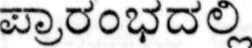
ಪ್ರಾರಂಭದಲ್ಲಿ
